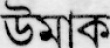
উমাক
